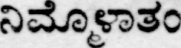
ನಿಮ್ಮೊಳಾತಂ
